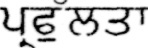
ਪ੍ਰਫੁੱਲਤਾ
